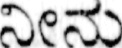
ನೀನು
